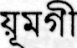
য়ূমগী
